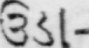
ઉડા-
